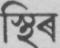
স্থিৰ
